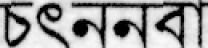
চৎননবা
